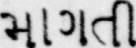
માગતી
